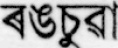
ৰঙচুৱা
